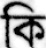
কি
